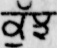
ਕੁੱਝ
